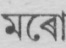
মৰো
